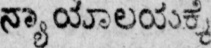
ನ್ಯಾಯಾಲಯಕ್ಕೆ
